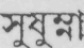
সুষুম্না
